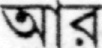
আর
